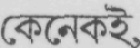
কেনেকই,
